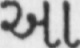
આ
